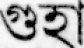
গুহা
